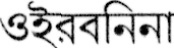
ওইরবনিনা
